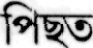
পিছত
